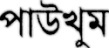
পাউখুম
